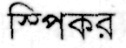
স্পিকর
